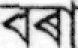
বৰা
